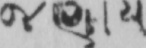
જણાય
